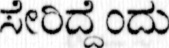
ಸೇರಿದ್ದೆಂದು
